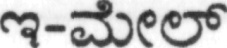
ಇ-ಮೇಲ್
